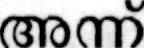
അന്ന്
